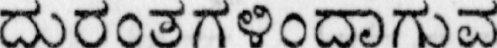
ದುರಂತಗಳಿಂದಾಗುವ
